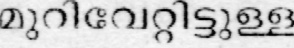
മുറിവേറ്റിട്ടുള്ള
